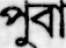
পুবা
